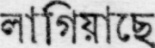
লাগিয়াছে
